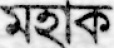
মহাক
